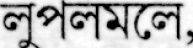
লুপলমলে,
